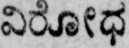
ವಿರೋಧ
